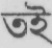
তই
